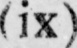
(ix)
